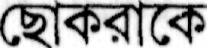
ছোকরাকে
